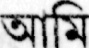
আমি
